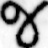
જ
